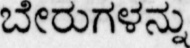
ಬೇರುಗಳನ್ನು
